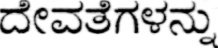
ದೇವತೆಗಳನ್ನು
